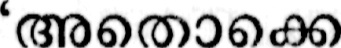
‘അതൊക്കെ
